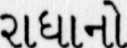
રાધાનો
